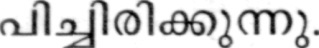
പിച്ചിരിക്കുന്നു.
